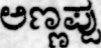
ಅಣ್ಣಪ್ಪು
